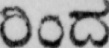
ರಿಂದ
